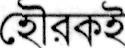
হৌরকই
